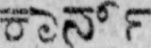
ಕಾರ್ನ್
